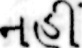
નહીં
